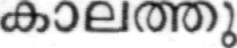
കാലത്തു
